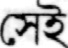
সেই
